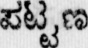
ಪಟ್ಟಣ
